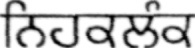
ਨਿਹਕਲੰਕ
